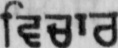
ਵਿਚਾਰ
